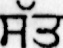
ਸੱਤ
